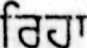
ਰਿਹਾ
